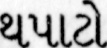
થપાટો
